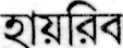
হায়রিব
